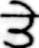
ਤੇ
